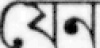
যেন
